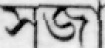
সজা
